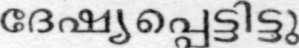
ദേഷ്യപ്പെട്ടിട്ടു
